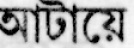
আটায়ে
